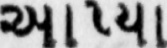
આપ્યા
